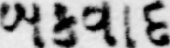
બકવાદ
